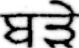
ਬੜੇ
